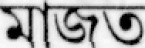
মাজত
